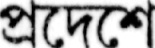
প্রদেশে
